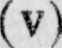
(v)
